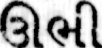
ઊભી
